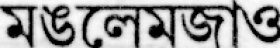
মঙলেমজাও
